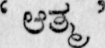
‘ಆತ್ಮ’
